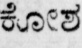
ಕೋಶ
